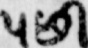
પછી
